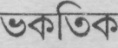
ভকতিক
